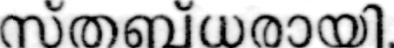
സ്തബ്ധരായി.
